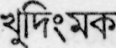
খুদিংমক
